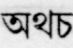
অথচ
